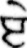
ਏ
